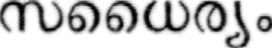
സധൈര്യം
